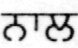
ਨਾਲ
